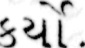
કર્યો.
